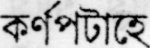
কর্ণপটাহে
